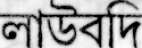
লাউবদি
